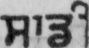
ਸਾਡੀ
